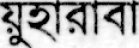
য়ুহারাবা
